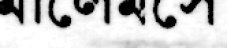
মালেমসু
